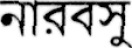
নারবসু
